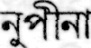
নুপীনা
